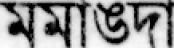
মমাঙদা
